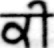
ਕੀ
